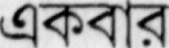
একবার
